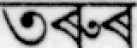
তৰুৰ
